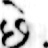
છે.
